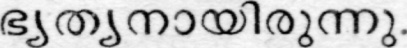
ഭ്യത്യനായിരുന്നു.
